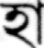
হা
